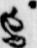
હું
